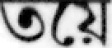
তয়ে
